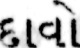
દાવો
